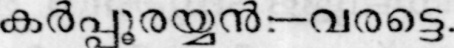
കര്‍പ്പൂരയ്യന്‍:-വരട്ടെ.
